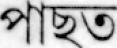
পাছত
